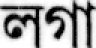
লগা
